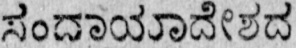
ಸಂದಾಯಾದೇಶದ
